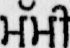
ਮੱਮੀ
